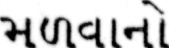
મળવાનો
